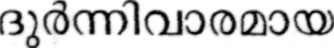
ദുര്‍ന്നിവാരമായ
